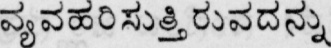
ವ್ಯವಹರಿಸುತ್ತಿರುವದನ್ನು
